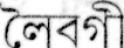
লৈবগী
